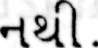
નથી.
